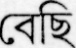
বেছি
